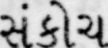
સંકોચ
